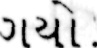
ગયો.
